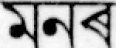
মনৰ
